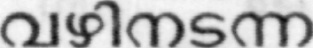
വഴിനടന്ന
